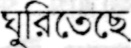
ঘুরিতেছে
